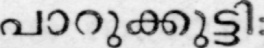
പാറുക്കുട്ടി:
